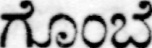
ಗೊಂಬೆ
